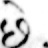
છે.
